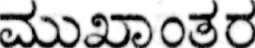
ಮುಖಾಂತರ
